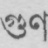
গুণ
